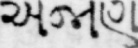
અજાણ
